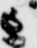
હું
